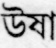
উষা
